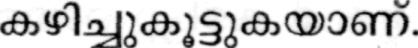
കഴിച്ചുകൂട്ടുകയാണ്.
